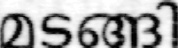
മടങ്ങി
